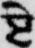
ਏ
